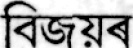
বিজয়ৰ
